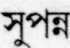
সুপন্ন
